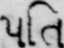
પતિ
